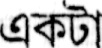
একটা
